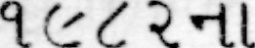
૧૯૮૨ના
